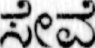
ಸೇವೆ
